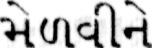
મેળવીને
